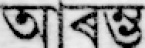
আৰম্ভ
